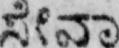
ಸೇವಾ
